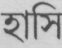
হাসি
